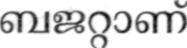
ബജറ്റാണ്
